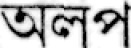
অলপ
